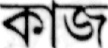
কাজ
